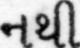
નથી
